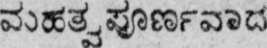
ಮಹತ್ವಪೂರ್ಣವಾದ
